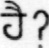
ਹੈ?
